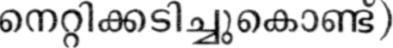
നെറ്റിക്കടിച്ചുകൊണ്ട്)
